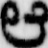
ಆ
